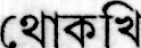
থোকখি
